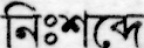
নিঃশব্দে
